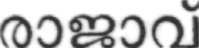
രാജാവ്
